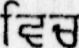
ਵਿਚ
